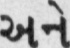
અને
